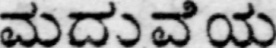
ಮದುವೆಯ
